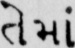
તેમાં
